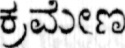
ಕ್ರಮೇಣ
